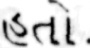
હતો.
